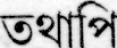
তথাপি
